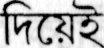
দিয়েই
